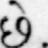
છે.
